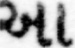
આ
